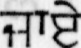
ਜਾਏ
